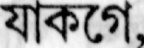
যাকগে,
